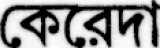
কেরেদা
